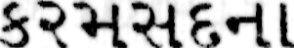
કરમસદના
